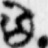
છે.
